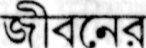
জীবনের
